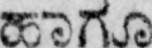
ಹಾಗೂ
